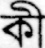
কী
